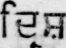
ਦ੍ਰਿਸ਼
